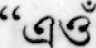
"এওঁ
